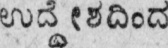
ಉದ್ದೇಶದಿಂದ
